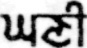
ਘਣੀ
